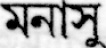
মনাসু
